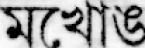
মখোঙ
